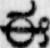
ಈ
